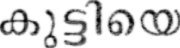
കുട്ടിയെ
